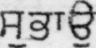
ਸੁਭਾਉ
